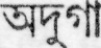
অদুগা
